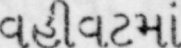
વહીવટમાં
